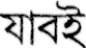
যাবই
